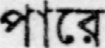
পারে
